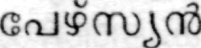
പേഴ്സ്യന്‍
